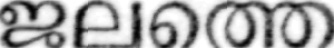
ജലത്തെ
